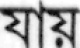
যায়
